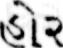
હોર
